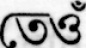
তেওঁ
